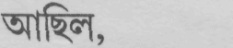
আছিল,
